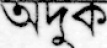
অদুক
